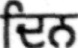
ਦਿਨ
